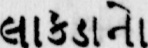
લાકડાનો
